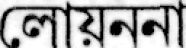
লোয়ননা
